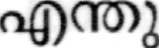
എന്തു
